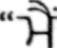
''ਮੈਂ
